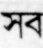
সব
